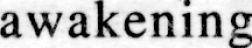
awakening
